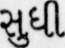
સુધી
